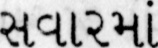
સવારમાં
